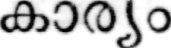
കാര്യം
